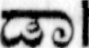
ಡಾ|
